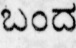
ಬಂದ
